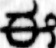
ಈ
